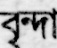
বৃন্দা
